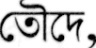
তৌদে,
